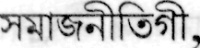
সমাজনীতিগী,
